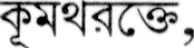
কুমথরক্তে,
